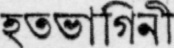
হতভাগিনী
